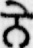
ਨੇ
